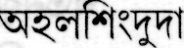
অহলশিংদুদা
